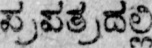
ಪ್ರುಪತ್ರದಲ್ಲಿ
